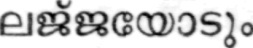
ലജ്ജയോടും
